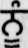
ਨੂੰ
